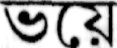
ভয়ে
